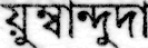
য়ুম্বান্দুদা
